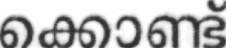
ക്കൊണ്ട്
